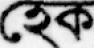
হেক
